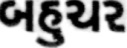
બહુચર
